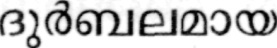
ദുര്‍ബലമായ
